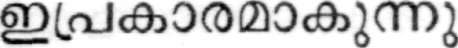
ഇപ്രകാരമാകുന്നു
